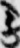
કે
